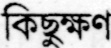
কিছুক্ষণ
